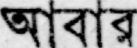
আবার
